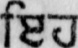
ਇਹ
